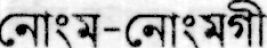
নোংম-নোংমগী
